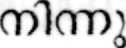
നിന്നു
